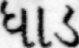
ધાડ
